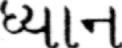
ધ્યાન
